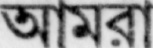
আমরা
